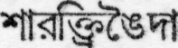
শারক্ত্রিঙৈদা
